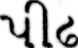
પીઢ
